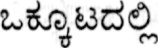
ಒಕ್ಕೂಟದಲ್ಲಿ
